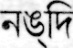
নঙদি
